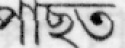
পাছত
